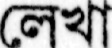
লেখা
